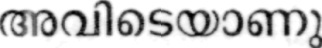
അവിടെയാണു
